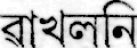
ৱাখলনি
